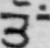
ਤੋਂ
